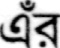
এঁর
